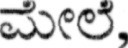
ಮೇಲೆ,
